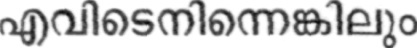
എവിടെനിന്നെങ്കിലും
